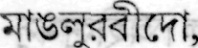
মাঙলুরবীদো,
